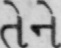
તેને
